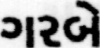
ગરબે
